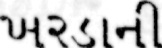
ખરડાની
